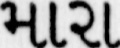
મારા
